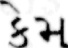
કેમ
